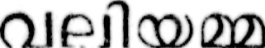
വലിയമ്മ
